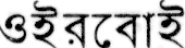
ওইরবোই
